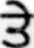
ਤੇ
